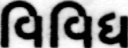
વિવિધ
